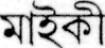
মাইকী
